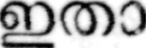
ഇതാ
